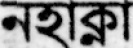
নহাক্না
